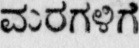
ಮರಗಳಿಗೆ
